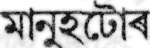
মানুহটোৰ
